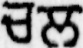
ਚਲ
